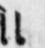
તો
